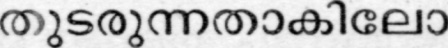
തുടരുന്നതാകിലോ
